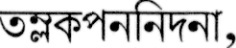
তম্লকপনিদনা,
